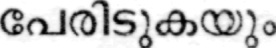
പേരിടുകയും
